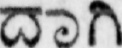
ದಾಗಿ
